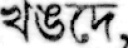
খঙদে,
